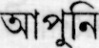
আপুনি
